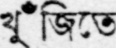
খুঁজিতে
